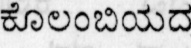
ಕೊಲಂಬಿಯದ
